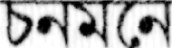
চনমনে
